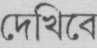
দেখিবে
